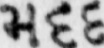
મદદ
